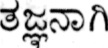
ತಜ್ಞನಾಗಿ
